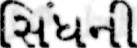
સિંધની
